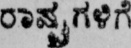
ರಾಷ್ಟ್ರಗಳಿಗೆ
